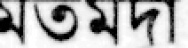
মতমদা
